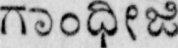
ಗಾಂಧೀಜಿ
